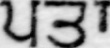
ਪਤਾ
